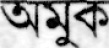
অমুক
